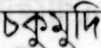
চকুমুদি
